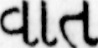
વાત
